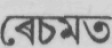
ৰেচমত
